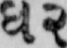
ઘર
